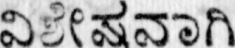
ವಿಶೇಷವಾಗಿ
